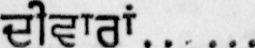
ਦੀਵਾਰਾਂ.........
